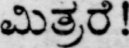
ಮಿತ್ರರೆ!
